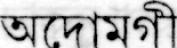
অদোমগী
